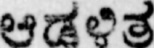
ಆಡಳಿತ
